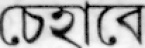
চেহাবে
